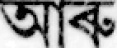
আৰু
